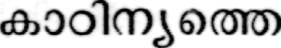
കാഠിന്യത്തെ
